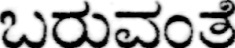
ಬರುವಂತೆ
